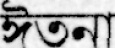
ঈতনা
